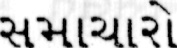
સમાચારો
